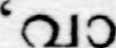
‘വാ
